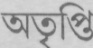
অতৃপ্তি
